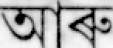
আৰু
